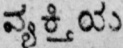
ವ್ಯಕ್ತಿಯ
